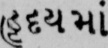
હ્રદયમાં
